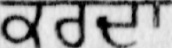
ਕਰਦਾ
